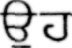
ਉਹ
